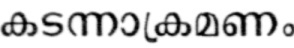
കടന്നാക്രമണം
